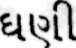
ઘણી
